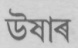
উষাৰ
